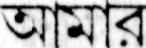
আমার
